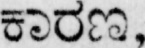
ಕಾರಣ,
